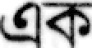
এক
